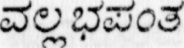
ವಲ್ಲಭಪಂತ
